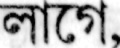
লাগে,
